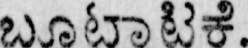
ಬೂಟಾಟಿಕೆ.
